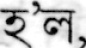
হ'ল,
